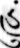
હું
